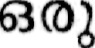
ഒരു
